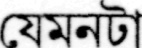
যেমনটা
